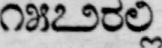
೧೫೭೨ರಲ್ಲಿ
